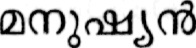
മനുഷ്യന്‍
